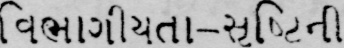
વિભાગીયતા-સૃષ્ટિની
